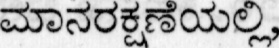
ಮಾನರಕ್ಷಣೆಯಲ್ಲಿ,
